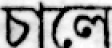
চালে
